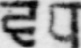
ਵਧ
